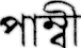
পাম্বী
